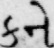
કને
